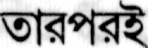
তারপরই
